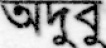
অদুবু
